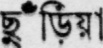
ছুঁড়িয়া
